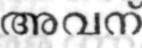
അവന്
